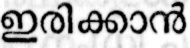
ഇരിക്കാന്‍
